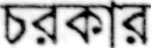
চরকার
